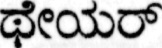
ಥೇಯರ್
